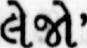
લેજો'
